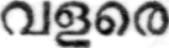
വളരെ
